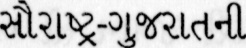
સૌરાષ્ટ્ર-ગુજરાતની
